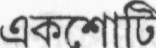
একশোটি
